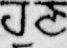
ਹੁਣ
